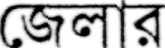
জেলার
